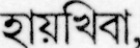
হায়খিবা,
